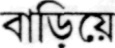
বাড়িয়ে
